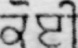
ਕੋਈ
